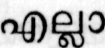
എല്ലാ
